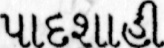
પાદશાહી
